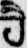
ਹੈ
